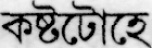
কষ্টটোহে
